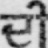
ਦੀ
